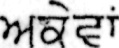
ਅਕੇਵਾਂ
